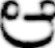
ಆ
